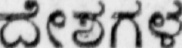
ದೇಶಗಳ
